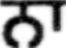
ਨਾ
